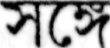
সঙ্গে
